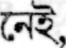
নেই,
